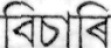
বিচাৰি
